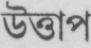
উত্তাপ
